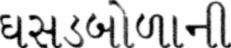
ધસડબોળાની
